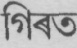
গিৰত
